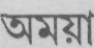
অময়া
